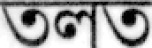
তলত
